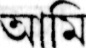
আমি
